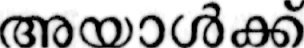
അയാള്‍ക്ക്
